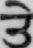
ਤੇ
